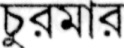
চুরমার
